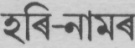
হৰি-নামৰ
